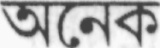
অনেক
